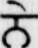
ਨੇ
